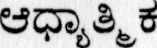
ಆಧ್ಯಾತ್ಮಿಕ
